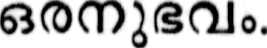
ഒരനുഭവം.
